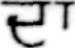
ਦਾ
